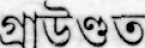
গ্ৰাউণ্ডত
